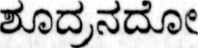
ಶೂದ್ರನದೋ
